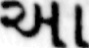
આ
